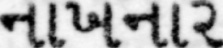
નાખનાર
